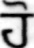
ਹੋ
